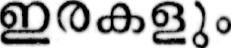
ഇരകളും
